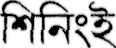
শিনিংই
